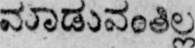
ಮಾಡುವಂತಿಲ್ಲ
